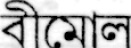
বীমোল
